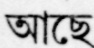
আছে
